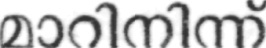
മാറിനിന്ന്
